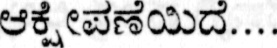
ಆಕ್ಷೇಪಣೆಯಿದೆ....
